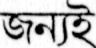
জন্যই
